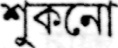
শুকনো
